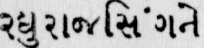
રઘુરાજસિંગને
